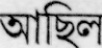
আছিল
